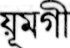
য়ূমগী
